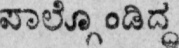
ಪಾಲ್ಗೊಂಡಿದ್ದ
